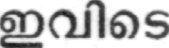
ഇവിടെ
